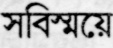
সবিস্ময়ে
